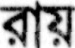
রায়
